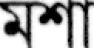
মশা
